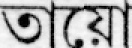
তায়ো
